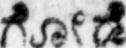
ಗೋಡೆ
